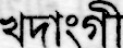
খদাংগী
